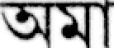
অমা
